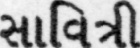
સાવિત્રી
